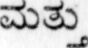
ಮತ್ತು
